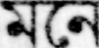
মনে
